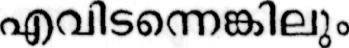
എവിടന്നെങ്കിലും
